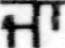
ਜਾ
